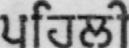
ਪਹਿਲੀ
